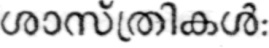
ശാസ്ത്രികള്‍:
